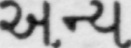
અન્ય
